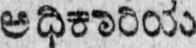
ಅಧಿಕಾರಿಯ
